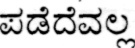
ಪಡೆದೆವಲ್ಲ
